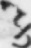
કે
